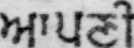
ਆਪਣੀ
